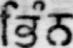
ਭਿੰਨ
